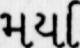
મર્યા
